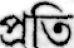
প্রতি
